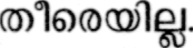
തീരെയില്ല.
